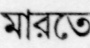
মারতে
